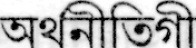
অর্থনিতিগী
